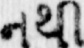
નથી
